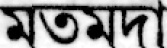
মতমদা
